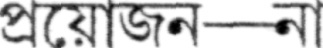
প্রয়োজন–না
